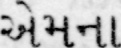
એમના
